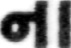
ના
